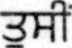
ਤੁਸੀਂ
